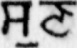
ਸੁਣ
